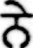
ਨੇ
